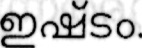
ഇഷ്ടം.
